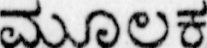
ಮೂಲಕ
